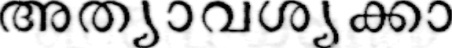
അത്യാവശ്യക്കാ
